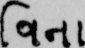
વિના
